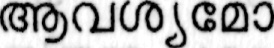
ആവശ്യമോ
